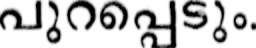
പുറപ്പെടും.
